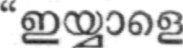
“ഇയ്യാളെ
